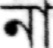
না
